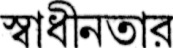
স্বাধীনতার
